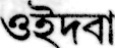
ওইদবা
